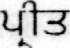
ਪ੍ਰੀਤ
